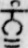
ਨੂੰ
